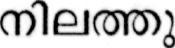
നിലത്തു
